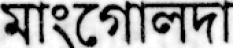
মাংগোলদা
